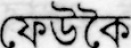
ফেউকৈ
